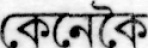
কেনেকৈ
